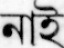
নাই
